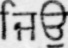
ਜਿਉ
